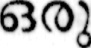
ഒരു
